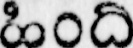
ಹಿಂದಿ
